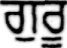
ਗੁਰੂ
